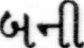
બની
